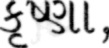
કૃષ્ણા,
